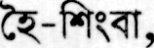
হৈ-শিংবা,
